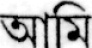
আমি
